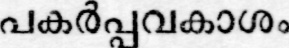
പകര്‍പ്പവകാശം
